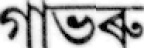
গাভৰু
